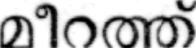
മീറത്ത്
